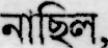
নাছিল,
